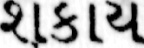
શકાય
